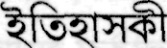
ইতিহাসকী
